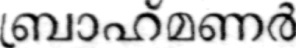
ബ്രാഹ്മണര്‍
